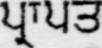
ਪ੍ਰਾਪਤ
